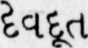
દેવદૂત
